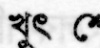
খুৎ
